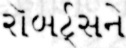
રૉબર્ટસને
